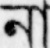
না
